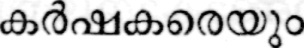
കര്‍ഷകരെയും
